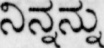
ನಿನ್ನನ್ನು
